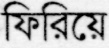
ফিরিয়ে
